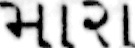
મારા
